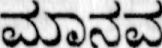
ಮಾನವ
